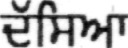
ਦੱਸਿਆ
